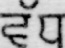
ਵੱਧ
